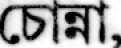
চোন্না,
